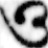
ও
